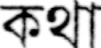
কথা
